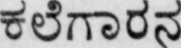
ಕಲೆಗಾರನ
